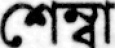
শেম্বা
